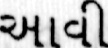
આવી
